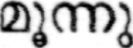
മൂന്നു
